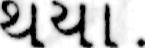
થયા.
